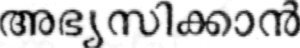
അഭ്യസിക്കാന്‍
